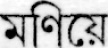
মণিয়ে
